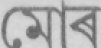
মোৰ
